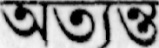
অত্যন্ত
